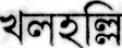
খলহল্লি
